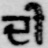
ਦੀ
